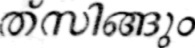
ത്സിങ്ങും
